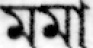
মমা
